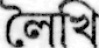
লৈখি
